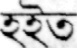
হইত
